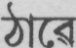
ঠাৱে
